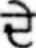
ਦੇ
